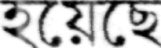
হয়েছে
